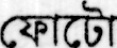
ফোটো
